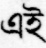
এই
